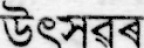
উৎসৱৰ
